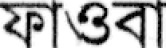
ফাওবা
